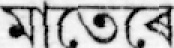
মাতেৰে
